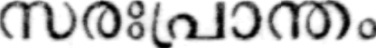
സരഃപ്രാന്തം
